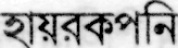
হায়রকপনি
